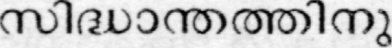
സിദ്ധാന്തത്തിനു
